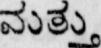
ಮತ್ತು
